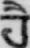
ਹੈ
